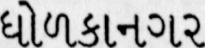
ધોળકાનગર
